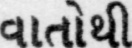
વાતોથી
